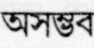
অসম্ভব
